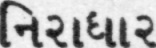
નિરાધાર
